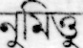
নুমিত্তু
